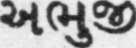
અભુજી
